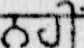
ਨਹੀਂ
